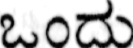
ಒಂದು
